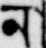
না
